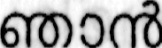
ഞാന്‍
